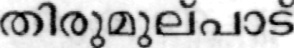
തിരുമുല്പാട്
